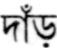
দাঁড়
